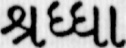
શ્રધ્ધા
